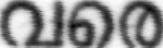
വരെ
